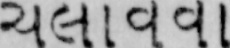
ચલાવવા
